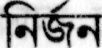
নির্জন
